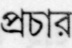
প্রচার
